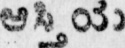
ಅಸ್ತಿಯ
